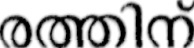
രത്തിന്
